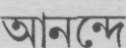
আনন্দে
